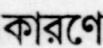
কারণে
